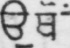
ਉਥੋਂ
